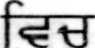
ਵਿਚ
